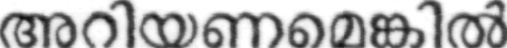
അറിയണമെങ്കില്‍
